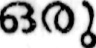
ഒരു
